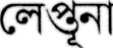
লেপ্তূনা
